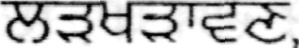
ਲੜਖੜਾਵਣ,
